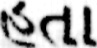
હતા
